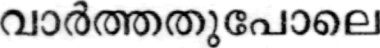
വാര്‍ത്തതുപോലെ
